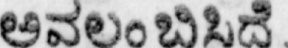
ಅವಲಂಬಿಸಿದೆ.
